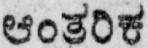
ಆಂತರಿಕ
